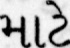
માટે
